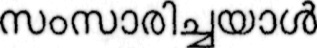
സംസാരിച്ചയാള്‍
